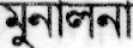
মুনালনা
